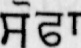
ਸੋਫਾ
